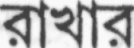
রাখার
